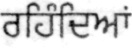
ਰਹਿੰਦਿਆਂ
